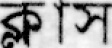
ক্লাস
